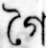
গৈ
